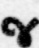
જ
